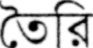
তৈরি
